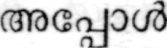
അപ്പോള്‍
